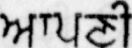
ਆਪਣੀ
